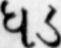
ધડ
